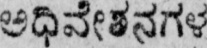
ಅಧಿವೇಶನಗಳ
